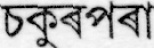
চকুৰপৰা
